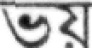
ভয়
